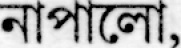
নাপালো,
